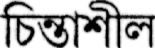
চিন্তাশীল
